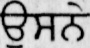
ਉਸਨੇ
